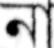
না
